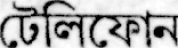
টেলিফোন
